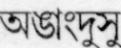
অঙাংদুসু
